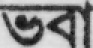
ভবা
